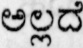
ಅಲ್ಲದೆ
